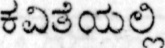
ಕವಿತೆಯಲ್ಲಿ
